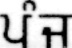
ਪੰਜ
